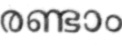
രണ്ടാം
